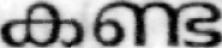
കണ്ട
